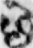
છે
